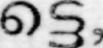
ട്ടെ,
